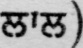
ਲਾਲ)
